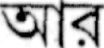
আর
